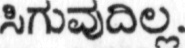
ಸಿಗುವುದಿಲ್ಲ.
